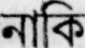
নাকি
